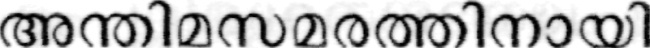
അന്തിമസമരത്തിനായി
